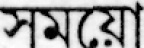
সময়ো
